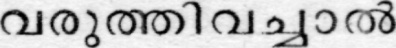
വരുത്തിവച്ചാല്‍
